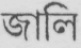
জালি
